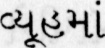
વ્યૂહમાં
